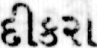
દીકરા
